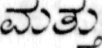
ಮತ್ತು
